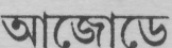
আজোড়ে
